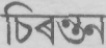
চিৰন্তন
